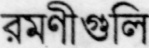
রমণীগুলি
